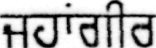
ਜਹਾਂਗੀਰ
